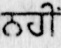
ਨਹੀਂ
